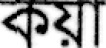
কয়া
